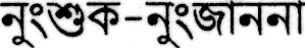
নুংশুক-নুংজাননা
